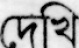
দেখি
